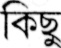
কিছু
